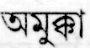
অমুক্কা
